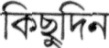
কিছুদিন
